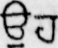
ਉਹ
